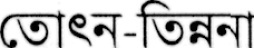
তোৎন-তিন্ননা
